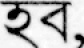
হব,
